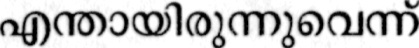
എന്തായിരുന്നുവെന്ന്
